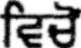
ਵਿਚੋਂ
